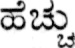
ಹೆಚ್ಚು
